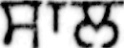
ਸਾਲ
